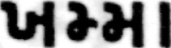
ખમ્મા
